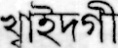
খ্বাইদগী
